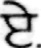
ਏ.
